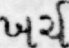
ખર્ચ
